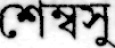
শেম্বসু
